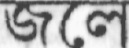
জলে
